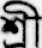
শ্রী
